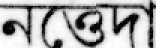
নত্তেদা
